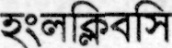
হংলক্লিবসি
